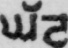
ਘੱਟ
